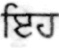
ਇਹ
